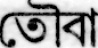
তৌবা
